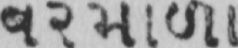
વરમાળા
